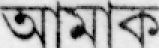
আমাক
